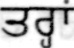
ਤਰ੍ਹਾਂ
